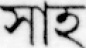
সাহ
